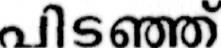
പിടഞ്ഞ്
